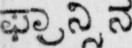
ಫ್ರಾನ್ಸಿನ
